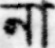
না
